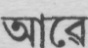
আৱে
